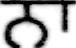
ਨਾ
